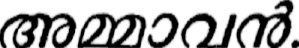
അമ്മാവന്‍.
